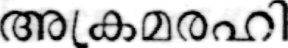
അക്രമരഹി
